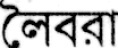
লৈবরা
